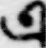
এ
